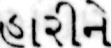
હારીને
